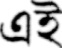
এই
